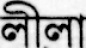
লীলা
